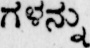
ಗಳನ್ನು
